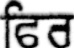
ਫਿਰ
